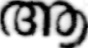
ആ
